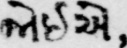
જોઈએ,
